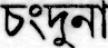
চংদুনা
